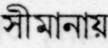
সীমানায়
